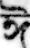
ঈ
